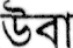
উবা
